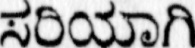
ಸರಿಯಾಗಿ
